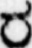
ರ
